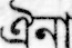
ঐনা
